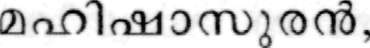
മഹിഷാസുരന്‍,
